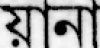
য়ানা
